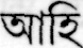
আহি
